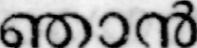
ഞാന്‍
